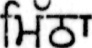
ਮਿੱਠਾ
